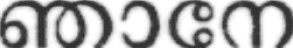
ഞാനേ
